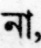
না,
